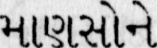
માણસોને
